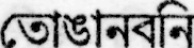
তোঙানবনি
